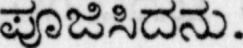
ಪೂಜಿಸಿದನು.
